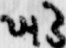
ખડે
